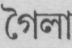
গৈলা
